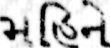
મહિને
